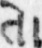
તો
